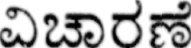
ವಿಚಾರಣೆ
